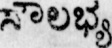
ಸೌಲಭ್ಯ
